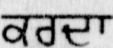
ਕਰਦਾ
